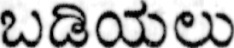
ಬಡಿಯಲು
